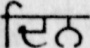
ਦਿਨ
